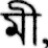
মী,
